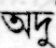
অদু
